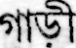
গাড়ী
